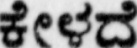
ಕೇಳದೆ
